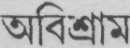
অবিশ্ৰাম
